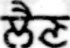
ਲੈਣ
